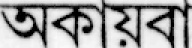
অকায়বা
